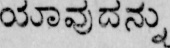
ಯಾವುದನ್ನು
